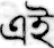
এই
